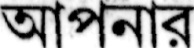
আপনার
